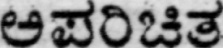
ಅಪರಿಚಿತ
